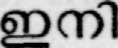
ഇനി
